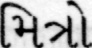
મિત્રો
